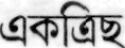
একত্রিছ
